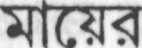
মায়ের
